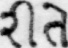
રીતે
